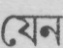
যেন
